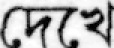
দেখে
